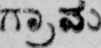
ಗ್ರಾಮ
